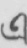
এ
